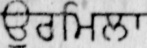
ਉਰਮਿਲਾ
